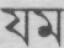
যম
